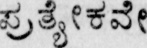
ಪ್ರತ್ಯೇಕವೇ
